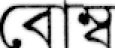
বোম্ব
